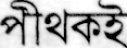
পীথকই
